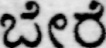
ಬೇರೆ
